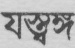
যস্ত্বঙ্গ
